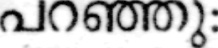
പറഞ്ഞു:
